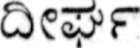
ದೀರ್ಘ
